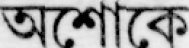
অশোকে
